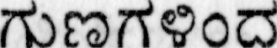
ಗುಣಗಳಿಂದ
